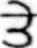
ਤੇ
